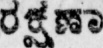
ರಕ್ಷಣಾ
